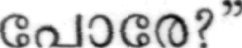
പോരേ?"
